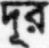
দূর
